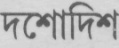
দশোদিশ
